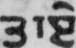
ਤਾਏ
